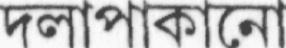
দলাপাকানো
